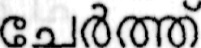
ചേര്‍ത്ത്
